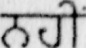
ਨਹੀਂ
